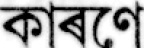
কাৰণে
